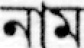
নাম
